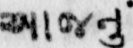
આજનું
